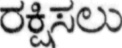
ರಕ್ಷಿಸಲು
